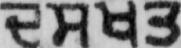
ਦਸਖਤ
